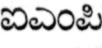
ಐಎಂಪಿ
